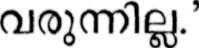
വരുന്നില്ല.’
